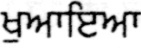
ਖੁਆਇਆ
